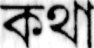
কথা
